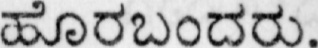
ಹೊರಬಂದರು.
